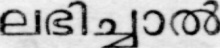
ലഭിച്ചാല്‍
